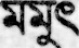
মমুৎ
